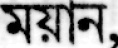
ময়ান,
